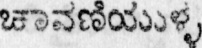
ಚಾವಣಿಯುಳ್ಳ
